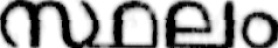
സ്ഥലം
